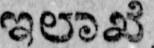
ಇಲಾಖೆ
